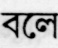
বলে
